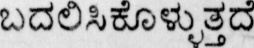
ಬದಲಿಸಿಕೊಳ್ಳುತ್ತದೆ
